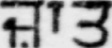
ਜ਼ਾਤ
